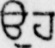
ਉਹ
